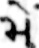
મેં
